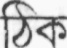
ঠিক
